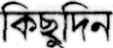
কিছুদিন
